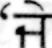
'ਜੇ
